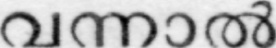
വന്നാല്‍
